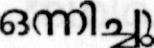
ഒന്നിച്ചു
